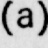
(a)
